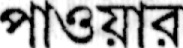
পাওয়ার
